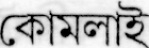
কোমলাই
